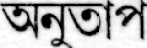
অনুতাপ
